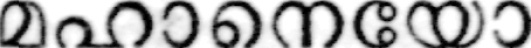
മഹാനെയോ
